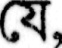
যে,
